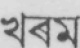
খৰম
